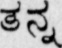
ತನ್ನ
